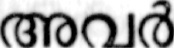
അവര്‍
